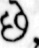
છે,
